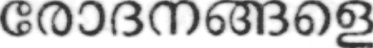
രോദനങ്ങളെ
